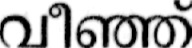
വീഞ്ഞ്
